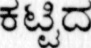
ಕಟ್ಟಿದ
